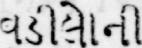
વડીલોની
